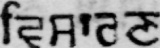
ਵਿਸਾਰਣ
